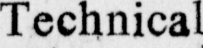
Technical
